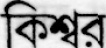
কিশ্বর
